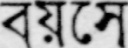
বয়সে
